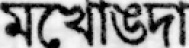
মখোঙদা
